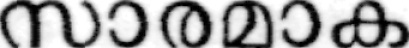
സാരമാക
